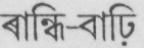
ৰান্ধি-বাঢ়ি
